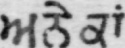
ਅਨੇਕਾਂ
